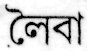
লৈবা
